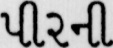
પીરની
